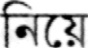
নিয়ে
